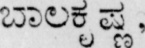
ಬಾಲಕೃಷ್ಣ,
